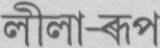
লীলা-ৰূপ
